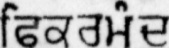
ਫਿਕਰਮੰਦ
